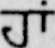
ਹਾਂ
